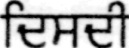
ਦਿਸਦੀ
